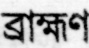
ব্রাহ্মণ
